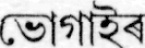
ভোগাইৰ
